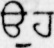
ਉਹ
